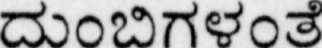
ದುಂಬಿಗಳಂತೆ
